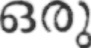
ഒരു
